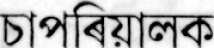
চাপৰিয়ালক
